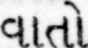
વાતો
